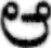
ಆ
